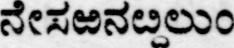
ನೇಸಱನೞ್ದಲುಂ
